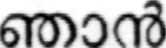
ഞാന്‍
